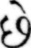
છે
